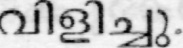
വിളിച്ചു.
